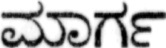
ಮಾರ್ಗ
